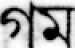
গম
